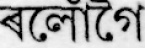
ৰলোঁগৈ
